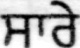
ਸਾਰੇ
